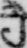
ਹੈ
